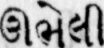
ઊભેલી
